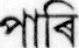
পাৰি
